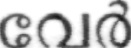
വേര്‍
